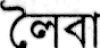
লৈবা
